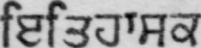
ਇਤਿਹਾਸਕ
